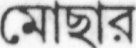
মোছার
